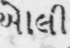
બોલી
